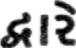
દ્વારે
